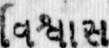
વિશ્વાસ
